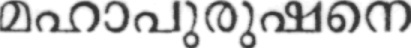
മഹാപുരുഷനെ
